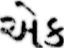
એક
